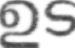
ഉട
